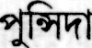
পুন্সিদা
